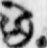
છે.
